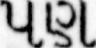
પણ
